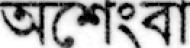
অশেংবা
